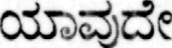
ಯಾವುದೇ
